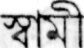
স্বামী
